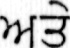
ਅਤੇ
